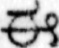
ಈ
